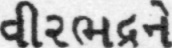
વીરભદ્રને
